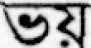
ভয়
